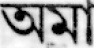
অমা
